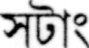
সটাং
